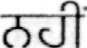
ਨਹੀਂ
